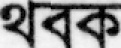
থবক
